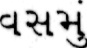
વસમું
